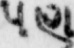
પણ
